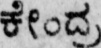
ಕೇಂದ್ರ
